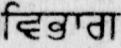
ਵਿਭਾਗ
